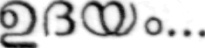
ഉദയം...
